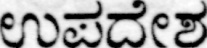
ಉಪದೇಶ
